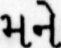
મને
